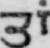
ਤਾਂ
